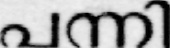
പന്നി
